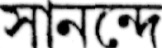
সানন্দে
